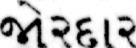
જોરદાર
